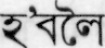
হ'বলৈ
